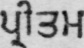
ਪ੍ਰੀਤਮ
